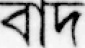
বাদ
